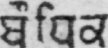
ਬੌਧਿਕ
